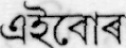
এইবোৰ
